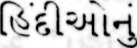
હિંદીઓનું
